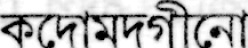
কদোমদগীনো
